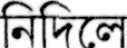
নিদিলে
